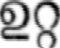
ഉറ്റ
